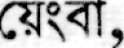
য়েংবা,
